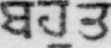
ਬਹੁਤ
